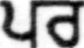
ਪਰ
